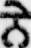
ਨੇ
